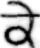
ਕੇ
